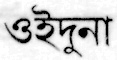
ওইদুনা
